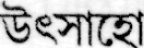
উৎসাহো
